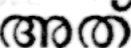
അത്
